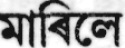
মাৰিলে
